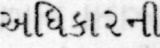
અધિકારની
